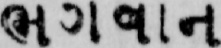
ભગવાન
